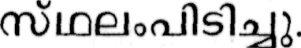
സ്ഥലംപിടിച്ചു.
